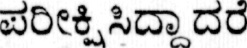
ಪರೀಕ್ಷಿಸಿದ್ದಾದರೆ
